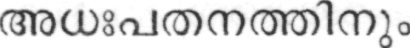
അധഃപതനത്തിനും
